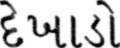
દેખાડો
